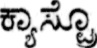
ಕ್ಯಾಸ್ಟ್ರೂ
